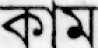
কাম
